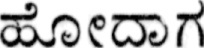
ಹೋದಾಗ
